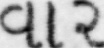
વાર
